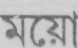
ময়ো
